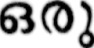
ഒരു
